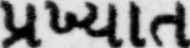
પ્રખ્યાત
